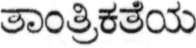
ತಾಂತ್ರಿಕತೆಯ
